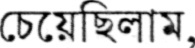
চেয়েছিলাম,
